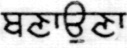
ਬਣਾਉਣਾ
